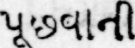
પૂછવાની
